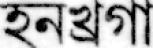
হনখ্রগা
